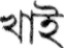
খাই
